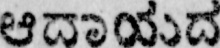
ಆದಾಯದ
